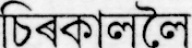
চিৰকাললৈ
